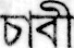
চাবী
